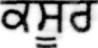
ਕਸੂਰ
